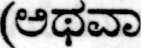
(ಅಥವಾ
